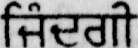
ਜਿੰਦਗੀ
